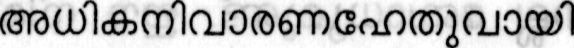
അധികനിവാരണഹേതുവായി
